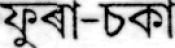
ফুৰা-চকা
